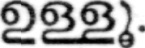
ഉളള്ളൂ.
